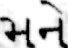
મને
